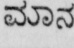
ಮಾನ
